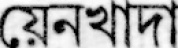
য়েনখাদা
